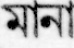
মানা
